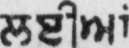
ਲਈਆਂ
